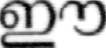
ഈ
